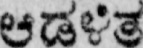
ಆಡಳಿತ
